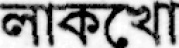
লাকখো
